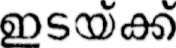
ഇടയ്ക്ക്
